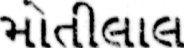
મોતીલાલ
